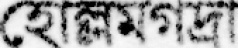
হোল্লমগদ্রা
